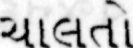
ચાલતો
